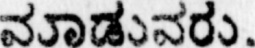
ಮಾಡುವರು.
